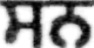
ਸਨ
